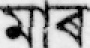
মাৰ
